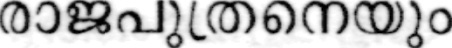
രാജപുത്രനെയും
